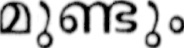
മുണ്ടും
